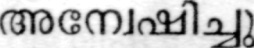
അന്വേഷിച്ചു
